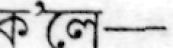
ক'লে-
